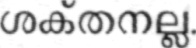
ശക്തനല്ല.
